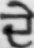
ਦੇ
